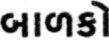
બાળકો
